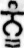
ਨੂੰ
